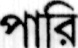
পারি
